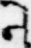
ને
